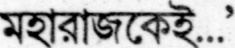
মহারাজকেই...’
